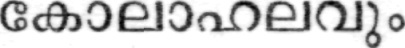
കോലാഹലവും
